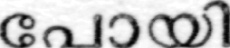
പോയി
